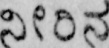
ನೀರಿನ
